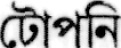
টোপনি
